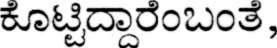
ಕೊಟ್ಟಿದ್ದಾರೆಂಬಂತೆ,
